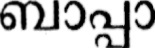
ബാപ്പാ
